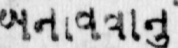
બનાવવાનું
